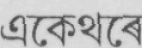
একেথৰে
